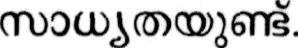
സാധ്യതയുണ്ട്.
